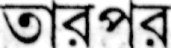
তারপর
